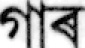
গাৰ
